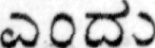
ಎಂದು
